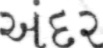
અંદર
